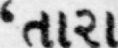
'તારા
